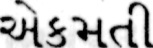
એકમતી
